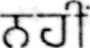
ਨਹੀਂ
